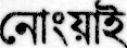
নোংয়াই
